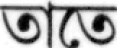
তাতে
